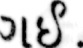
ગઈ.
